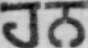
ਹਨ
